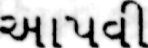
આપવી
